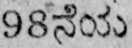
ನೆಯ
